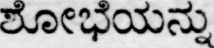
ಶೋಭೆಯನ್ನು
